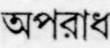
অপরাধ
